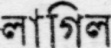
লাগিল
